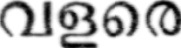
വളരെ
